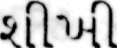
શીખી
